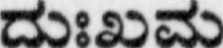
ದುಃಖಮ
